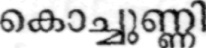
കൊച്ചുണ്ണി
